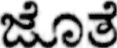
ಜೊತೆ
